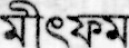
মীৎফম
